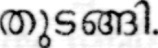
തുടങ്ങി.
